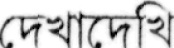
দেখাদেখি
